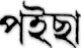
পইছা
